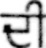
ਦੀ
